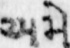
અમે
